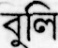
বুলি
